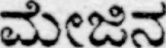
ಮೇಜಿನ
